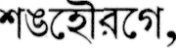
শঙহৌরগে,
